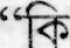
"কি
